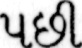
પછી
